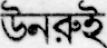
উনরুই
